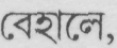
বেহালে,
